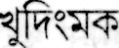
খুদিংমক
